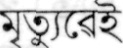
মৃত্যুৱেই
